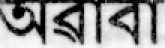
অৱাবা
